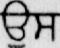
ਉਸ
